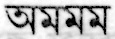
অমমম
